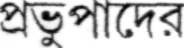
প্রভুপাদের
